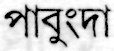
পাবুংদা
